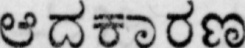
ಆದಕಾರಣ
